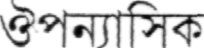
ঔপন্যাসিক
